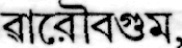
ৱারৌবগুম,
